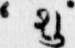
'શું
